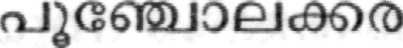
പൂഞ്ചോലക്കര
